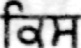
ਕਿਸ
